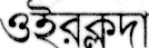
ওইরক্লদা
